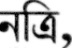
নত্রি,
